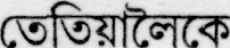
তেতিয়ালৈকে
